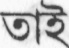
তাই
